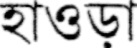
হাওড়া
